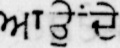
ਆਉਂਦੇ
